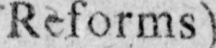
Reforms)
